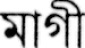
মাগী
